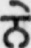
ਨੇ
